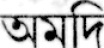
অমদি
